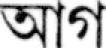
আগ
